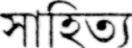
সাহিত্য
